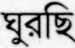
ঘুরছি
